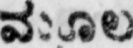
ಮೂಲ
